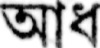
আধ
